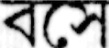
বসে
